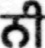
ਨੀ
